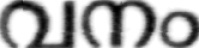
വനം
